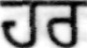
ਹਰ
